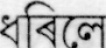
ধৰিলে
